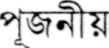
পূজনীয়
